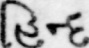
હિન્દ
